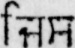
ਜਿਸ
